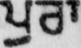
ਪੁਰਾ
